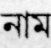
নাম
